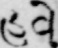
હવે
